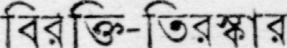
বিরক্তি-তিরস্কার
